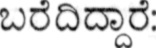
ಬರೆದಿದ್ದಾರೆ:
